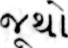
જૂથો
